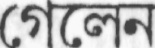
গেলেন
